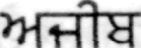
ਅਜੀਬ
